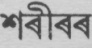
শৰীৰৰ
